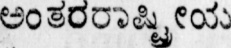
ಅಂತರರಾಷ್ಟ್ರೀಯ
